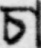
চা
